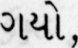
ગયો,
